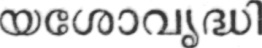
യശോവൃദ്ധി
